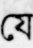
যে
